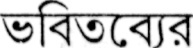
ভবিতব্যের
